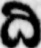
ದಿ
